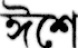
ঈশে
